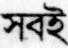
সবই
